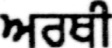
ਅਰਥੀ
